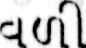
વળી
